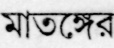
মাতঙ্গের
